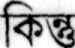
কিন্তু
